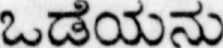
ಒಡೆಯನು
